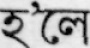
হ'লে
